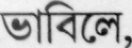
ভাবিলে,
